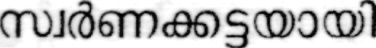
സ്വര്‍ണക്കട്ടയായി
